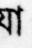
যা
